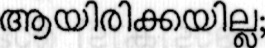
ആയിരിക്കയില്ല;
